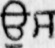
ਉਸ
